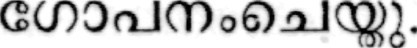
ഗോപനംചെയ്തു.
